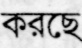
করছে
